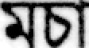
মচা
